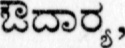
ಔದಾರ್‍ಯ,
